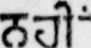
ਨਹੀਂ
